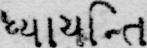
ધ્યાયન્તિ
